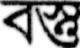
বস্তু
